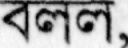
বলল,
